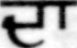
ਦਾ
